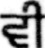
ਵੀ
